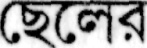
ছেলের
